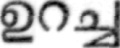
ഉറച്ച
